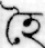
হৈ
